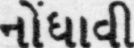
નોંધાવી
